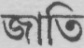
জাতি
